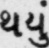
થયું
